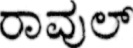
ರಾವುಲ್
